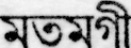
মতমগী
